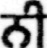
ਨੀ
